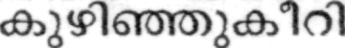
കുഴിഞ്ഞുകീറി
